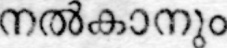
നല്‍കാനും
